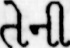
તેની
